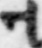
ન
